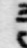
ਹੈ
